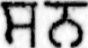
ਸਨ
